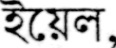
ইয়েল,
